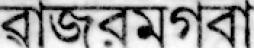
ৱাজরমগবা
